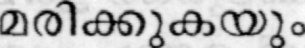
മരിക്കുകയും
